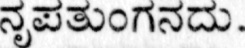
ನೃಪತುಂಗನದು.
